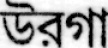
উরগা
